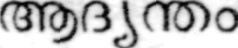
ആദ്യന്തം
